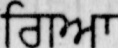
ਗਿਆ
